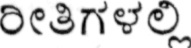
ರೀತಿಗಳಲ್ಲಿ
